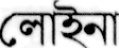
লোইনা
